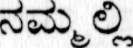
ನಮ್ಮಲ್ಲಿ
